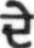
ਦੇ
